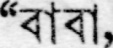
‘‘বাবা,
